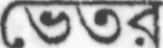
ভেতর
